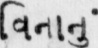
વિનાનું
